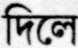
দিলে
